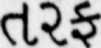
તરફ
